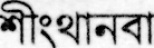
শীংথানবা
